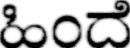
ಹಿಂದೆ
